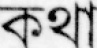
কথা
